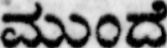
ಮುಂದೆ
